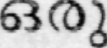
ഒരു
